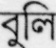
বুলি
